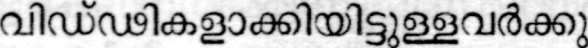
വിഡ്ഢികളാക്കിയിട്ടുള്ളവര്‍ക്കു
